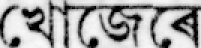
খোজেৰে
